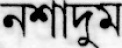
নশাদুম
